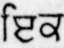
ਇਕ
